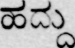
ಹದ್ದು
